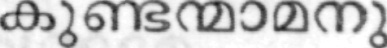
കുണ്ടന്മാമനു
